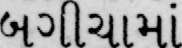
બગીચામાં
